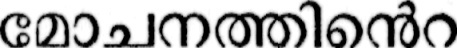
മോചനത്തിന്റെ
